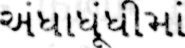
અંધાધૂંધીમાં
